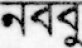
নববু
